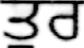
ਤੁਰ
